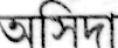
অসিদা
